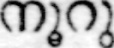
നൂറു
